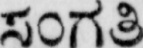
ಸಂಗತಿ
